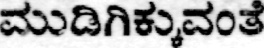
ಮುಡಿಗಿಕ್ಕುವಂತೆ
